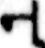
ન
